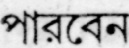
পারবেন
